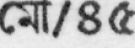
মৌ/৪৫
